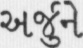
અર્જુને
